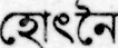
হোৎনৈ
